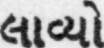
લાવ્યો
